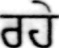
ਰਹੇ
